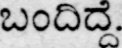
ಬಂದಿದ್ದೆ.
